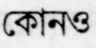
কোনও
